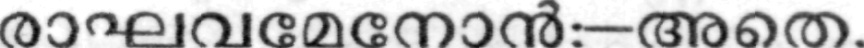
രാഘവമേനോന്‍:-അതെ,
